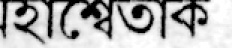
মহাশ্বেতাক
